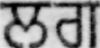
ਲਗ
